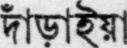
দাঁড়াইয়া
